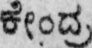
ಕೇಂದ್ರ
